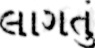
લાગતું
